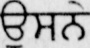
ਉਸਨੇ
